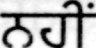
ਨਹੀਂ
